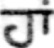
ਹਾਂ
